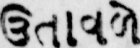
ઉતાવળે
